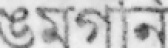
ঙমগনি
